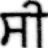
ਸੀ
